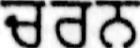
ਚਰਨ
